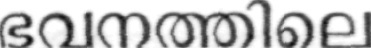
ഭവനത്തിലെ
